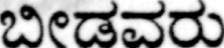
ಬೀಡವರು
